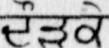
ਦੌੜਕੇ
